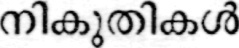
നികുതികള്‍
